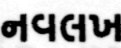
નવલખ
